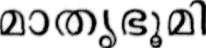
മാതൃഭൂമി
